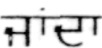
ਜਾਂਦਾ
